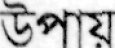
উপায়
